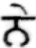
ਨੇ
